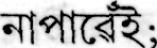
নাপাৱেঁই;
